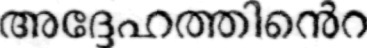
അദ്ദേഹത്തിന്റെ
